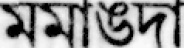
মমাঙদা
